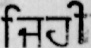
ਜਿਹੀ
